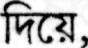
দিয়ে,
